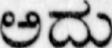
ಅದು
